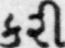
કરી
